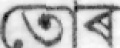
তোৰ
